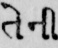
તેની
